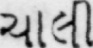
ચાલી
